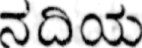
ನದಿಯ
